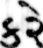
કરે
